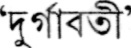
‘দুর্গাবতী’
